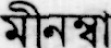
মীনম্বা
